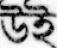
উই
